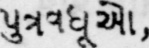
પુત્રવધૂઓ,
